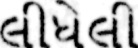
લીધેલી
